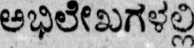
ಅಭಿಲೇಖಗಳಲ್ಲಿ
